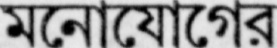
মনোযোগের
